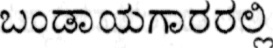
ಬಂಡಾಯಗಾರರಲ್ಲಿ
